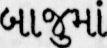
બાજુમાં
